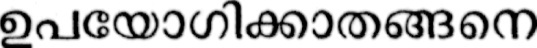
ഉപയോഗിക്കാതങ്ങനെ
